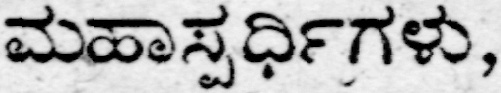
ಮಹಾಸ್ಪರ್ಧಿಗಳು,
